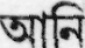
আনি
